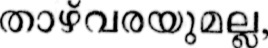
താഴ്വരയുമല്ല,
